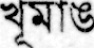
খূমাঙ
